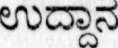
ಉದ್ದಾನ
